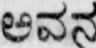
ಅವನ
